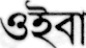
ওইবা
